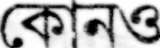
কোনও
